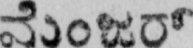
ಮೆಂಜರ್
